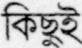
কিছুই
